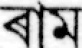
ৰাম
